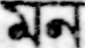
মন
